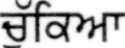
ਚੁੱਕਿਆ
